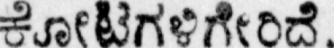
ಕೋಟಿಗಳಿಗೇರಿದೆ.
